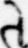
તે
